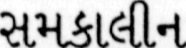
સમકાલીન
